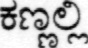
ಕಣ್ಣಲ್ಲಿ
